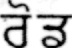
ਰੋਡ
